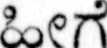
ಹೀಗೆ
